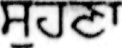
ਸੁਹਣਾ
